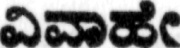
ವಿವಾಹೇ
